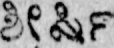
ಶೀರ್ಷಿ
